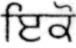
ਇਕੋ
